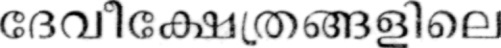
ദേവീക്ഷേത്രങ്ങളിലെ
